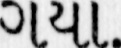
ગયા.
